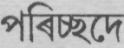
পৰিচ্ছদে
